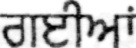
ਗਈਆਂ
